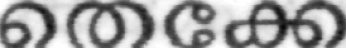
തെക്കേ
